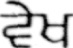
ਵੇਖ
